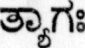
ತ್ಯಾಗಃ
